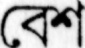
বেশ
